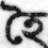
হৈ
